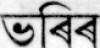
ভৰিৰ
